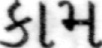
કામ
